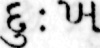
દુઃખ
